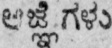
ಆಜ್ಞೆಗಳು
